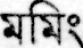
মমিং
